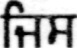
ਜਿਸ
